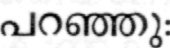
പറഞ്ഞു:
